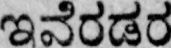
ಇವೆರಡರ
